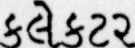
કલેકટર
